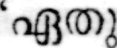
‘ഏതു
